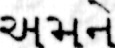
અમને
